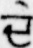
ਦੇ
